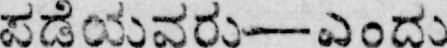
ಪಡೆಯುವರು-ಎಂದು
